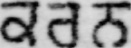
ਕਰਨ
